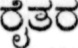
ರೈತರ
